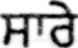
ਸਾਰੇ
